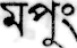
মপুং
